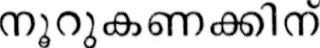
നൂറുകണക്കിന്
